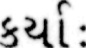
કર્યાઃ
